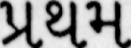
પ્રથમ
